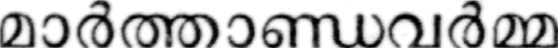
മാര്‍ത്താണ്ഡവര്‍മ്മ
